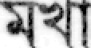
মখা
